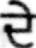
ਦੇ
